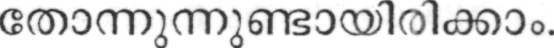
തോന്നുന്നുണ്ടായിരിക്കാം.
